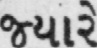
જ્યારે
